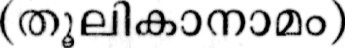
(തൂലികാനാമം)
